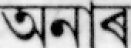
অনাৰ
